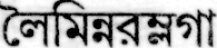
লৈমিন্নরম্লগা
